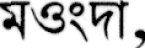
মওংদা,
